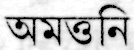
অমত্তনি
